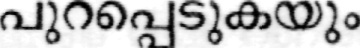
പുറപ്പെടുകയും
